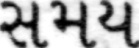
સમય
